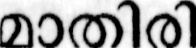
മാതിരി
